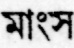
মাংস
